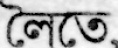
লৈতে,
